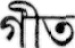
গীত
